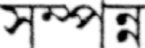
সম্পন্ন
